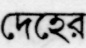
দেহের
